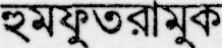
হুমফুতরামুক
